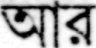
আর
